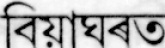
বিয়াঘৰত
